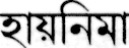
হায়নিমা
